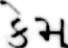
કેમ
